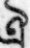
ঐ
